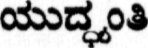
ಯುದ್ಧ್ಯಂತಿ
